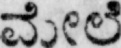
ಮೇಲೆ
